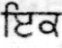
ਇਕ
